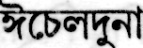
ঈচেলদুনা
